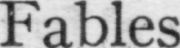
Fables
